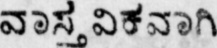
ವಾಸ್ತವಿಕವಾಗಿ
